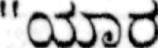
“ಯಾರ
